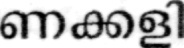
ണക്കളി
